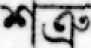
শত্রু
